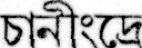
চানীংদ্রে
